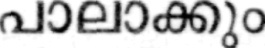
പാലാക്കും
